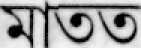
মাতত
